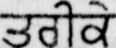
ਤਰੀਕੇ
